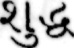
શુદ્ધ
